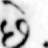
છે.
